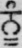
ਨੂੰ
